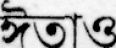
ঈতাও
